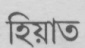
হিয়াত
